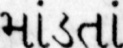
માંડતાં
